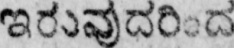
ಇರುವುದರಿಂದ
